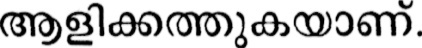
ആളിക്കത്തുകയാണ്.
